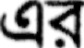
এর
